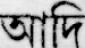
আদি
